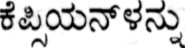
ಕೆಪ್ಸಿಯನ್ಳನ್ನು
